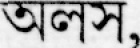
অলস,
